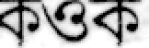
কওক
